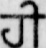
ਹੀ
